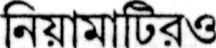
নিয়ামাটিরও
